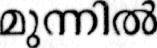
മുന്നില്‍
